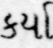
કર્યા
